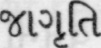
જાગૃતિ
